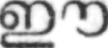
ഈ
